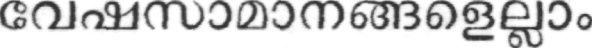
വേഷസാമാനങ്ങളെല്ലാം
